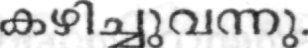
കഴിച്ചുവന്നു.
